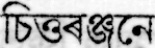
চিত্তৰঞ্জনে
